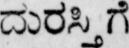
ದುರಸ್ತಿಗೆ
